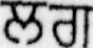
ਲਗ
